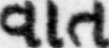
વાત
